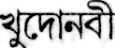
খুদোনবী
